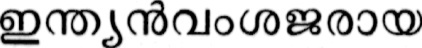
ഇന്ത്യന്‍വംശജരായ
